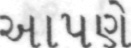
આપણે
